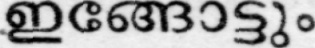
ഇങ്ങോട്ടും
